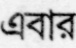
এবার
